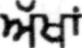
ਅੱਖਾਂ
